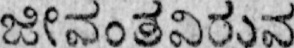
ಜೀವಂತವಿರುವ
